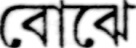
বোঝে
